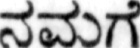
ನಮಗೆ
